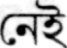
নেই
